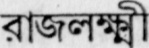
রাজলক্ষ্মী
